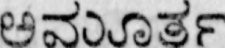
ಅಮೂರ್ತ
